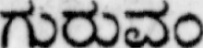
ಗುರುವಂ
